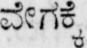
ವೇಗಕ್ಕೆ
